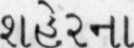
શહેરના
